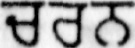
ਚਰਨ
